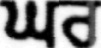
ਘਰ
